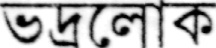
ভদ্রলোক
